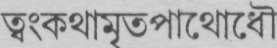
ত্বংকথামৃতপাথোধৌ
